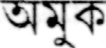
অমুক
